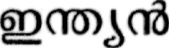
ഇന്ത്യന്‍
